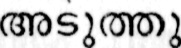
അടുത്തു
